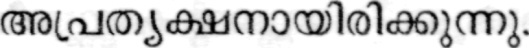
അപ്രത്യക്ഷനായിരിക്കുന്നു.
